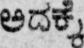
ಅದಕ್ಕೆ
